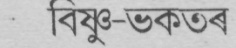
বিষ্ণু-ভকতৰ
